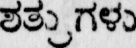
ಶತ್ರುಗಳು
